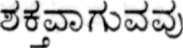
ಶಕ್ತವಾಗುವವು
